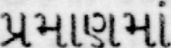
પ્રમાણમાં
